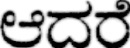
ಆದರೆ
